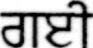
ਗਈ
